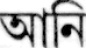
আনি
